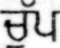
ਚੁੱਪ
